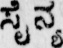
ಸೈನ್ಯ
